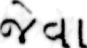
જેવા
